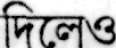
দিলেও
